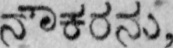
ನೌಕರನು,
